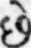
છે
